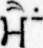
ਮੈਂ
